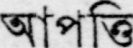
আপত্তি
